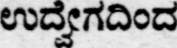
ಉದ್ವೇಗದಿಂದ
